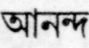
আনন্দ
